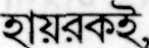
হায়রকই,
